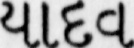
યાદવ
